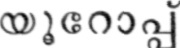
യൂറോപ്പ്
